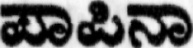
ಪಾಪಿನಾ
